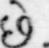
છે.
